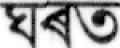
ঘৰত
